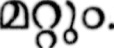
മറ്റും.
